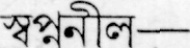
স্বপ্ননীল-
